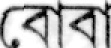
বোবা
